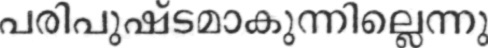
പരിപുഷ്ടമാകുന്നില്ലെന്നു
